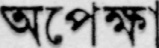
অপেক্ষা
